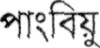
পাংবিয়ু
